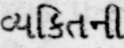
વ્યક્તિની
